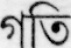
গতি
